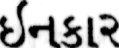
ઇનકાર
